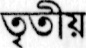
তৃতীয়
